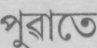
পুৱাতে
